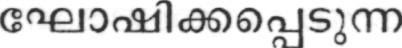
ഘോഷിക്കപ്പെടുന്ന
